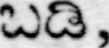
ಬಡಿ,
